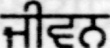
ਜੀਵਨ
